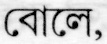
বোলে,
